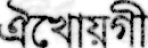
ঐখোয়গী
